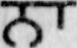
ਨਾ
